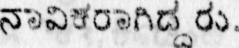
ನಾವಿಕರಾಗಿದ್ದರು.
